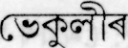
ভেকুলীৰ
